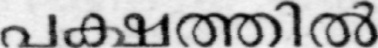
പക്ഷത്തില്‍
